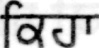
ਕਿਹਾ
